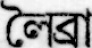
লৈব্রা
